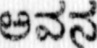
ಅವನ
